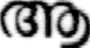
ആ
